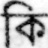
কি
